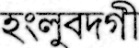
হংলুবদগী
